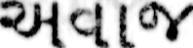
અવાજ
